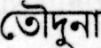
তৌদুনা
